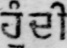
ਹੁੰਦੀ
